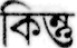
কিন্তু
